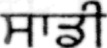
ਸਾਡੀ
